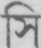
সি
